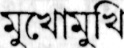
মুখোমুখি
